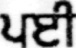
ਪਈ
